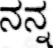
ನನ್ನ
